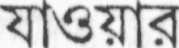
যাওয়ার
